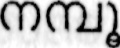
നമ്പൂ
